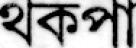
থকপা
